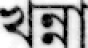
খন্না
